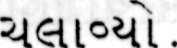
ચલાવ્યો.
